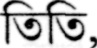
তিতি,
